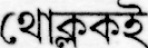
থোক্লকই
